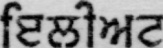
ਇਲੀਅਟ
